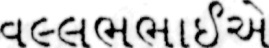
વલ્લભભાઈએ
